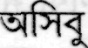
অসিবু
